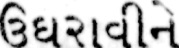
ઉઘરાવીને
